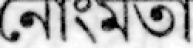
নোংমতা
